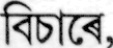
বিচাৰে,
